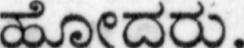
ಹೋದರು.
